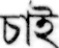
চাই
